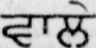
ਵਾਲੇ
